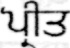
'ਪ੍ਰੀਤ
